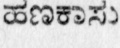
ಹಣಕಾಸು
